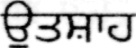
ਉਤਸ਼ਾਹ
